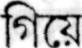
গিয়ে
